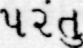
પરંતુ
